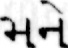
મને
